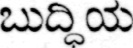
ಬುದ್ಧಿಯ
